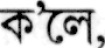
ক'লে,
